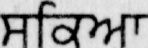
ਸਕਿਆ
